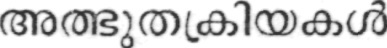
അത്ഭുതക്രിയകള്‍
